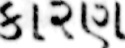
કારણ
